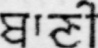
ਬਾਣੀ
